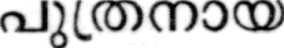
പുത്രനായ
